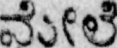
ಮೇಲೆ
